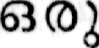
ഒരു
